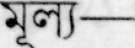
মূল্য-
